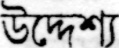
উদ্দেশ্য
